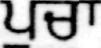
ਪੁਚਾ
